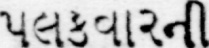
પલકવારની
